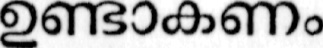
ഉണ്ടാകണം
